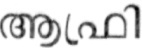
ആഫ്രി
